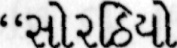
"સોરઠિયો
